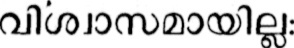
വിശ്വാസമായില്ല:
